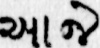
આજે
